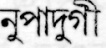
নুপাদুগী
